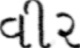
વીર
